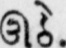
ઊઠે.
